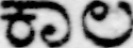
ಕಾಲ
